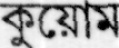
কুয়োম
